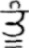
ਤੂੰ
